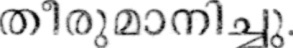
തീരുമാനിച്ചു.
